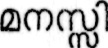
മനസ്സി
